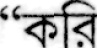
“করি
